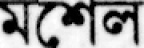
মশেল
